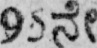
95ನೇ
